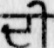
ਦੀ
